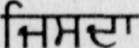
ਜਿਸਦਾ
